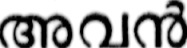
അവന്‍
